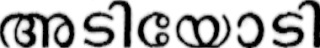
അടിയോടി
